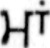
ਮਾਂ
